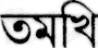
তমখি
